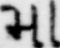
મા
